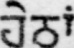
ਹੇਠਾਂ
